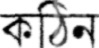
কঠিন
